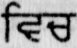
ਵਿਚ
